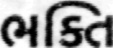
ભક્તિ
